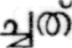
ച്ചത്
